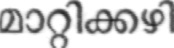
മാറ്റിക്കഴി
